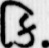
કિ.
